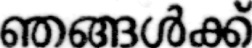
ഞങ്ങള്‍ക്ക്
